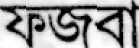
ফজবা
